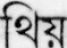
থিয়
